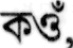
কওঁ,
